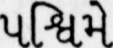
પશ્ચિમે
